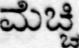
ಮೆಚ್ಚಿ
